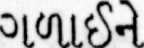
ગળાઈને
